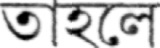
তাহলে
